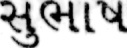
સુભાષ
